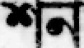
শন
